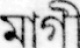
মাগী
